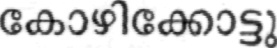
കോഴിക്കോട്ടു
